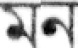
মন
